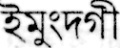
ইমুংদগী
